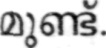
മുണ്ട്.
